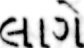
લાગે
